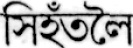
সিহঁতলৈ
